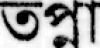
তপ্না
